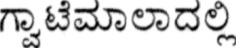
ಗ್ವಾಟೆಮಾಲಾದಲ್ಲಿ
